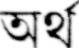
অর্থ
